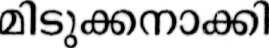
മിടുക്കനാക്കി
